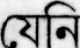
যেনি
